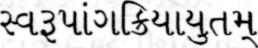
સ્વરૂપાંગક્રિયાયુતમ્
